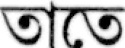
তাতে
